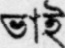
ভাই
